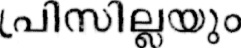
പ്രിസില്ലയും
